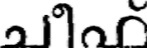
ചീഫ്
